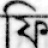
ফি
